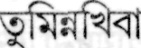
তুমিন্নখিবা
